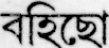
বহিছো
